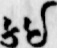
કઈ
